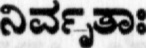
ನಿರ್ವೃತ್ತಾಃ
